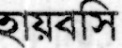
হায়বসি
